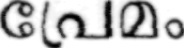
പ്രേമം
